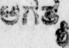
ಅಗತ್ಯ
